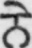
ਨੇ
